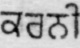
ਕਰਨੀ
